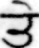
ਤੇ
